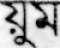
য়ুম
